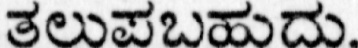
ತಲುಪಬಹುದು.
